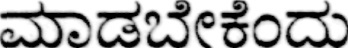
ಮಾಡಬೇಕೆಂದು
